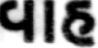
વાહ
